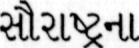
સૌરાષ્ટ્રના
